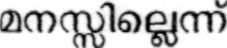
മനസ്സില്ലെന്ന്
